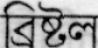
ব্ৰিষ্টল
